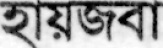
হায়জবা
